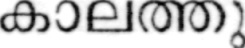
കാലത്തു
